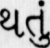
થતું
